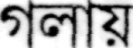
গলায়
